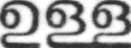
ഉള്ള
